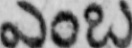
ಎಂಬ
